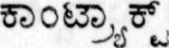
ಕಾಂಟ್ರ್ಯಾಕ್ಟ್
